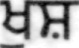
ਖੁਸ਼
